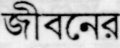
জীবনের
